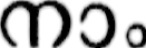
നാം
